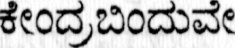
ಕೇಂದ್ರಬಿಂದುವೇ
